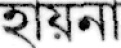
হায়না
